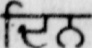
ਦਿਨ
